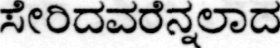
ಸೇರಿದವರೆನ್ನಲಾದ
